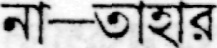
না—তাহার
